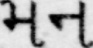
મન
